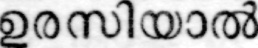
ഉരസിയാല്‍
